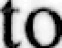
to
